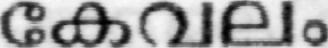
കേവലം
